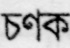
চণক
